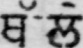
ਥੱਲੇ
